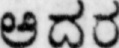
ಅದರ
